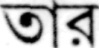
তার
